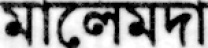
মালেমদা
